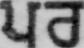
ਪਰ
